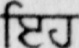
ਇਹ
